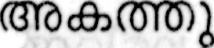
അകത്തു
